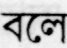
বলে
